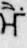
ਮੈਂ
